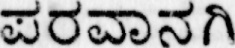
ಪರವಾನಗಿ
